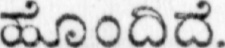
ಹೊಂದಿದೆ.
